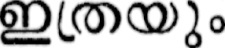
ഇത്രയും
